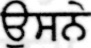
ਉਸਨੇ
